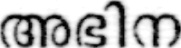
അഭിന
